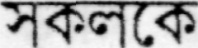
সকলকে
